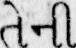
તેની
